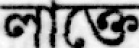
লাক্তে
